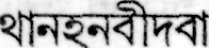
থানহনবীদবা
